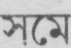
সমে
